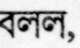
বলল,
